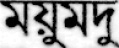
ময়ুমদু
